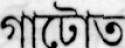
গাটোত
